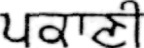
ਪਕਾਣੀ
